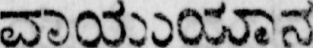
ವಾಯುಯಾನ
